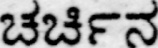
ಚರ್ಚಿನ
